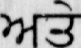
ਅਤੇ
